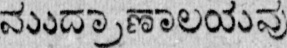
ಮುದ್ರಾಣಾಲಯವು
